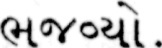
ભજવ્યો.
